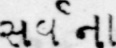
સર્વના
